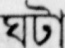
ঘটা
